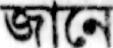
জানে
